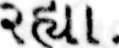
રહ્યા.
